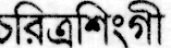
চরিত্রশিংগী
